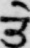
ਤੇ
